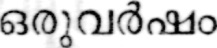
ഒരുവര്‍ഷം
